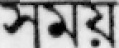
সময়
